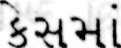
કેસમાં
